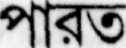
পারত
